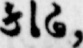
કાઢ,
